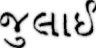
જુલાઈ
